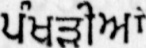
ਪੰਖੜੀਆਂ
